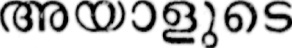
അയാളുടെ
